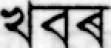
খবৰ
